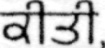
ਕੀਤੀ,
